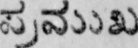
ಪ್ರಮುಖ
